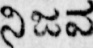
ನಿಜವ
